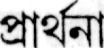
প্রার্থনা
